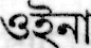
ওইনা
